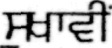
ਸੁਖਾਵੀਂ
